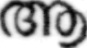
ആ
